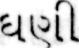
ઘણી
